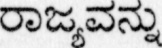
ರಾಜ್ಯವನ್ನು
